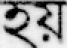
হয়
